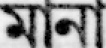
মানা
